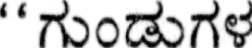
"ಗುಂಡುಗಳ
